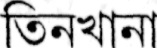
তিনখানা
